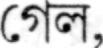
গেল,
